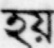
হয়
